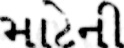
માટેની
